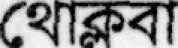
থোক্লবা
